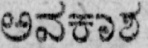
ಅವಕಾಶ
